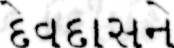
દેવદાસને
